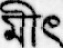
মীৎ
